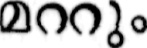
മററും
